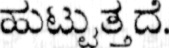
ಹುಟ್ಟುತ್ತದೆ.
